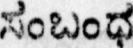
ಸಂಬಂಧ
